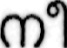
നീ
